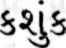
કશુંક
